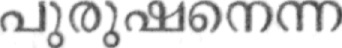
പുരുഷനെന്ന
